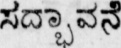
ಸದ್ಭಾವನೆ
